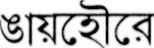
ঙায়হৌরে
